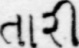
તારી
